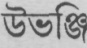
উভঞ্জি
